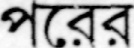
পরের
